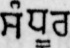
ਸੰਧੂਰ
